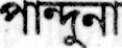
পান্দুনা
